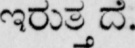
ಇರುತ್ತದೆ.
